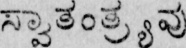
ಸ್ವಾತಂತ್ರ್ಯವು
